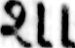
શા
